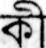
কী
